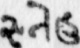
સ્નેહ
